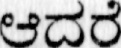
ಆದರೆ
